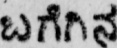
ಬಗೆಗಿನ
